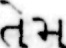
તેમ
